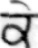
ਕੇ
